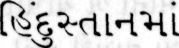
હિંદુસ્તાનમાં
